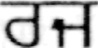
ਰਜ
